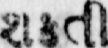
શકતી
